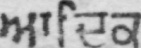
ਆਦਿਕ
